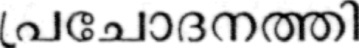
പ്രചോദനത്തി
